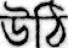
উঠি
